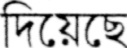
দিয়েছে
